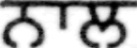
ਨਾਲ
